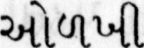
ઓળખી
